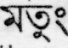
মতুং
